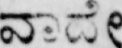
ವಾದೇ
